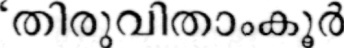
'തിരുവിതാംകൂര്‍
